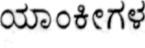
ಯಾಂಕೀಗಳ
